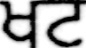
ਖਟ
